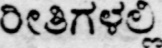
ರೀತಿಗಳಲ್ಲಿ
